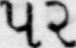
પર
